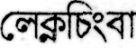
লেক্নচিংবা
